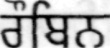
ਰੌਬਿਨ
